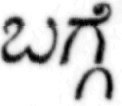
ಬಗ್ಗೆ
